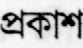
প্রকাশ
